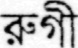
রুগী
